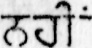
ਨਹੀਂ
